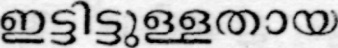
ഇട്ടിട്ടുള്ളതായ
